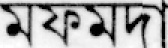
মফমদা
